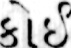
કોઈ
